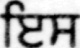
ਇਸ
